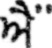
ਐ''
